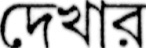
দেখার
